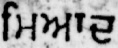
ਮਿਆਦ
